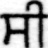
ਸੀ
